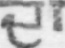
ਦਾ
